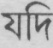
যদি
